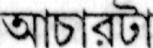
আচারটা
